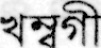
খম্বগী
